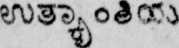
ಉತ್ಕ್ರಾಂತಿಯ
